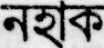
নহাক
